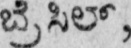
ಬ್ರೆಸಿಲ್,
